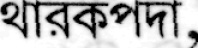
থারকপদা,
